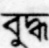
বুদ্ধ
